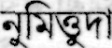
নুমিত্তুদা
